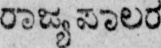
ರಾಜ್ಯಪಾಲರ
